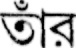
তাঁর
